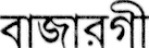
বাজারগী
